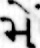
મેં
